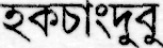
হকচাংদুবু
